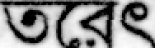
তরেৎ
